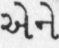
એને
